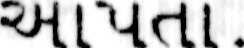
આપતા.
